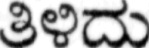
ತಿಳಿದು
